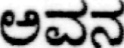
ಅವನ
